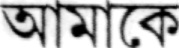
আমাকে
